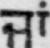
ਜਾਂ
